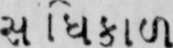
સધિકાળ
